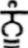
ਨੂੰ
